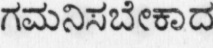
ಗಮನಿಸಬೇಕಾದ
